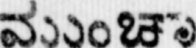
ಮುಂಚಾ
